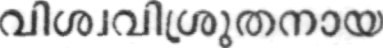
വിശ്വവിശ്രുതനായ
